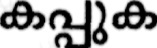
കപ്പുക
